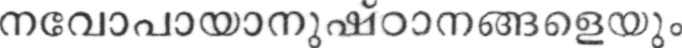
നവോപായാനുഷ്ഠാനങ്ങളെയും
